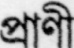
প্রাণী
